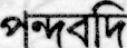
পন্দবদি
